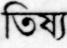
তিষ্য
